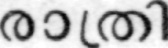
രാത്രി
